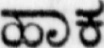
ಹಾಕ
